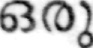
ഒരു
